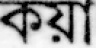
কয়া
